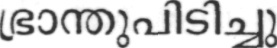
ഭ്രാന്തുപിടിച്ചു
